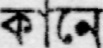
কানে
